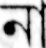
না
